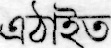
এঠাইত
